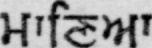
ਮਾਣਿਆ
